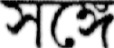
সঙ্গে
